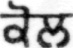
ਕੋਲ
